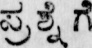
ಪ್ರಶ್ನೆಗೆ
